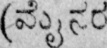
(ಮೈನರ
